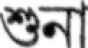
শুনা
